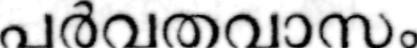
പര്‍വതവാസം
